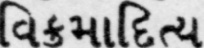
વિક્રમાદિત્ય
